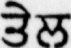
ਤੇਲ
